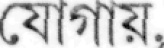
যোগায়,
